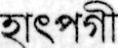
হাৎপগী
